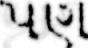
પણ
